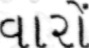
વારોં
